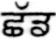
ਛੱਡ
